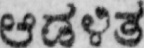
ಆಡಳಿತ
